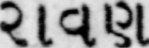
રાવણ
